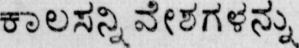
ಕಾಲಸನ್ನಿವೇಶಗಳನ್ನು
